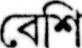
বেশি
